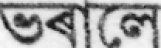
ভৰালে
